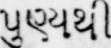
પુણ્યથી
